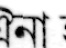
ঐনা
